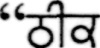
''ਠੀਕ
